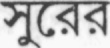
সুরের
